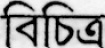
বিচিত্ৰ
